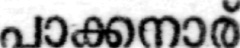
പാക്കനാര്
